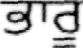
ਭਾਰੂ
